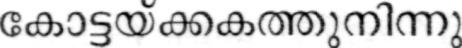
കോട്ടയ്ക്കകത്തുനിന്നു
